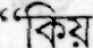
"কিয়
